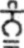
ਨੂੰ
